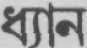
ধ্যান
